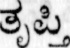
ತೃಪ್ತಿ
